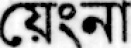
য়েংনা
